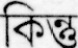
কিন্তু
